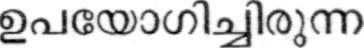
ഉപയോഗിച്ചിരുന്ന
